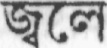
জ্বলে
